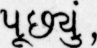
પૂછ્યું,
